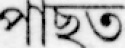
পাছত
